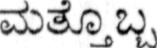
ಮತ್ತೊಬ್ಬ
